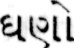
ઘણો
